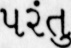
પરંતુ
